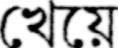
খেয়ে
